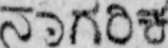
ನಾಗರಿಕ
